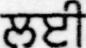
ਲਈ
